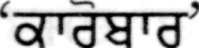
'ਕਾਰੋਬਾਰ'
